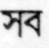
সব
